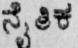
ನೈತಿಕ
